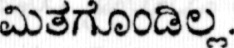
ಮಿತಗೊಂಡಿಲ್ಲ.
